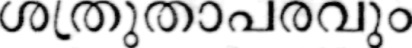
ശത്രുതാപരവും
